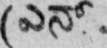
(ಎನ್.
